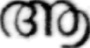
ആ
